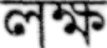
লক্ষ
